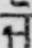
ਜੋ
